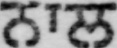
ਨਾਲ
